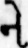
ને
